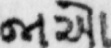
જાઓ
